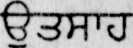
ਉਤਸਾਹ
